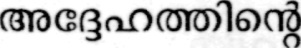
അദ്ദേഹത്തിന്റെ
